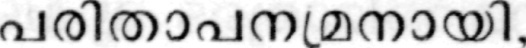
പരിതാപനമ്രനായി,
